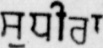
ਸੁਧੀਰਾ
